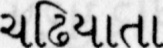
ચઢિયાતા
